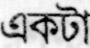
একটা
